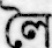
লৈ
